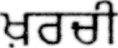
ਖ਼ਰਚੀ
